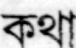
কথা
